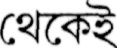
থেকেই
